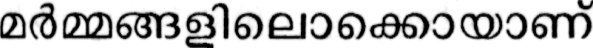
മര്‍മ്മങ്ങളിലൊക്കൊയാണ്
